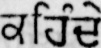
ਕਹਿੰਦੇ
